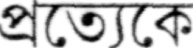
প্রত্যেকে
